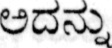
ಅದನ್ನು
